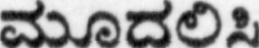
ಮೂದಲಿಸಿ
